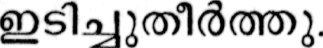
ഇടിച്ചുതീര്‍ത്തു.
